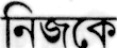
নিজকে
